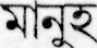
মানুহ
